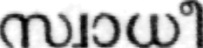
സ്വാധീ
